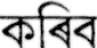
কৰিব
